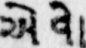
એવો
